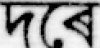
দৰে
